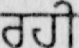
ਰਹੀ
